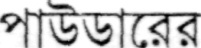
পাউডারের
